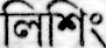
লিশিং
